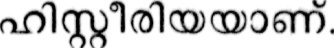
ഹിസ്റ്റീരിയയാണ്.
